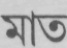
মাত
